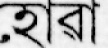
হোৱা
